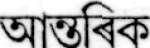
আন্তৰিক
